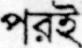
পরই
